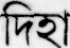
দিহা
